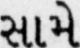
સામે
